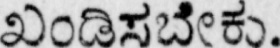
ಖಂಡಿಸಬೇಕು.
